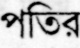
পতির
